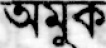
অমুক
